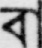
বা
